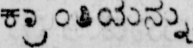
ಕ್ರಾಂತಿಯನ್ನು
